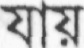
যায়
